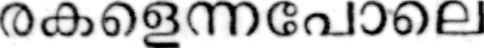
രകളെന്നപോലെ
